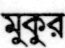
মুকুর
